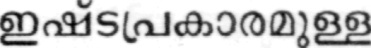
ഇഷ്ടപ്രകാരമുള്ള
